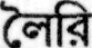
লৈরি
